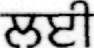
ਲਈ
